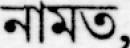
নামত,
